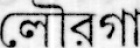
লৌরগা
